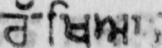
ਰੱਖਿਆ
